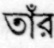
তাঁর
